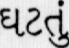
ઘટતું
